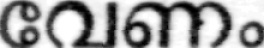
വേണം
